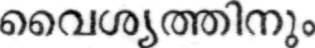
വൈശ്യത്തിനും
